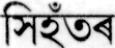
সিহঁতৰ
